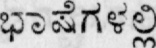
ಭಾಷೆಗಳಲ್ಲಿ
